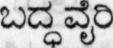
ಬದ್ಧವೈರಿ
